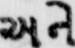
અને
